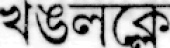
খঙলক্লে
